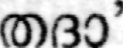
തദാ'
